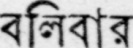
বলিবার
